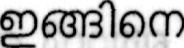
ഇങ്ങിനെ
